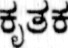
ಕೃತಕ
